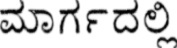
ಮಾರ್ಗದಲ್ಲಿ
